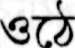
ওঠে
